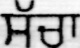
ਸੱਚਾ
